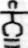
ਨੂੰ
